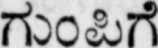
ಗುಂಪಿಗೆ
